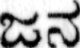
ಜನ
